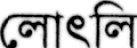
লোৎলি
